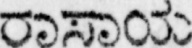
ರಾಸಾಯ
